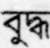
বুদ্ধ
